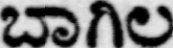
ಬಾಗಿಲ
